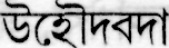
উহৌদবদা
